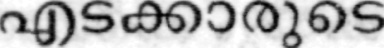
എടക്കാരുടെ
